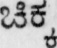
ಚಿಕ್ಕ
